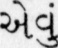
એવું
